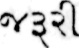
જરૂરી
